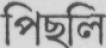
পিছলি
